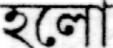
হলো
